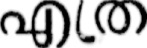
എത്ര
